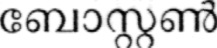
ബോസ്റ്റണ്‍
